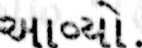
આવ્યો.
